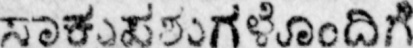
ಸಾಕುಪಶುಗಳೊಂದಿಗೆ
